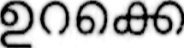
ഉറക്കെ
